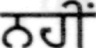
ਨਹੀਂ
